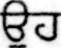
ਉਹ
